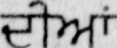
ਦੀਆਂ
